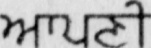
ਆਪਣੀ
